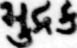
મુદ્રક
